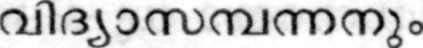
വിദ്യാസമ്പന്നനും
